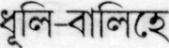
ধূলি-বালিহে
